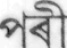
পৰী
